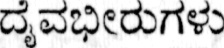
ದೈವಭೀರುಗಳು
